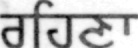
ਰਹਿਣਾ
